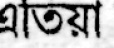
এতিয়া
